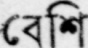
বেশি
